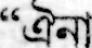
“ঐনা
